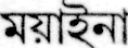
ময়াইনা
